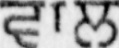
ਵਾਲ
